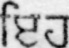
ਇਹ
